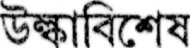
উল্কাবিশেষ
